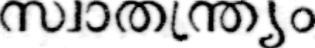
സ്വാതന്ത്ര്യം
